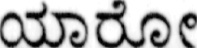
ಯಾರೋ
